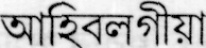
আহিবলগীয়া
